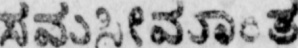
ಸಮಸೀಮಾಂತ
